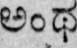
ಅಂಥ
